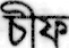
চীফ
